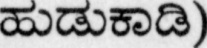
ಹುಡುಕಾಡಿ)
